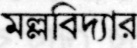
মল্লবিদ্যার
